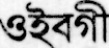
ওইবগী
